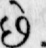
છે.
